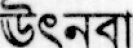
ঊৎনবা
